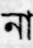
না
